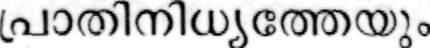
പ്രാതിനിധ്യത്തേയും
